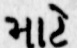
માટે
